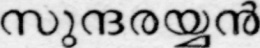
സുന്ദരയ്യന്‍
